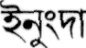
ইনুংদা
